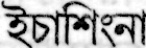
ইচাশিংনা
